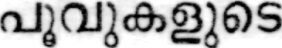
പൂവുകളുടെ
